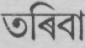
তৰিবা
